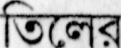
তিলের
